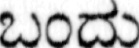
ಬಂದು
